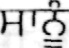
ਸਾਨੂੰ
